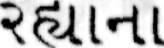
રહ્યાના
